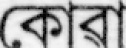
কোৱা
